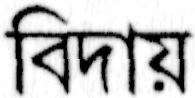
বিদায়
